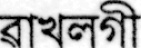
ৱাখলগী
